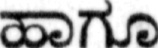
ಹಾಗೂ
